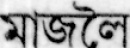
মাজলৈ
